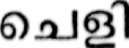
ചെളി
